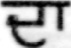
ਦਾ
